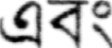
এবং
